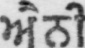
ਐਨੀ
